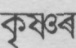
কৃষ্ণৰ
